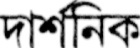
দার্শনিক
